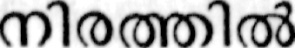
നിരത്തില്‍
